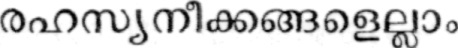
രഹസ്യനീക്കങ്ങളെല്ലാം
